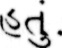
હતું.
